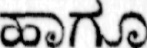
ಹಾಗೂ
